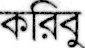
করিবু
